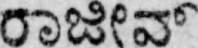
ರಾಜೀವ್
